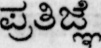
ಪ್ರತಿಜ್ಞೆ
